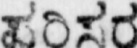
ಪರಿಸರ
